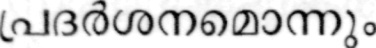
പ്രദര്‍ശനമൊന്നും
